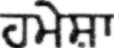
ਹਮੇਸ਼ਾ
